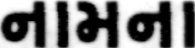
નામના
